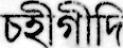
চহীগীদি
